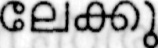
ലേക്കു
